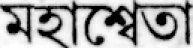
মহাশ্বেতা
